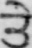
ਤੇ
